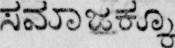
ಸಮಾಜಕ್ಕೂ
